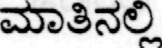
ಮಾತಿನಲ್ಲಿ
